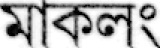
মাকলং
